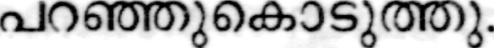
പറഞ്ഞുകൊടുത്തു.
